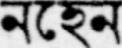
নহেন
